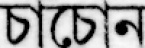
চাচোন
